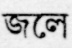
জলে
